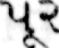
પૂર
